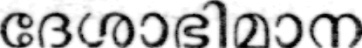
ദേശാഭിമാന
